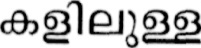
കളിലുള്ള
